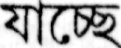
যাচ্ছে
